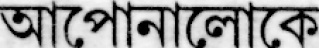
আপোনালোকে
